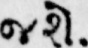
જશે.
